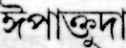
ঈপাক্তুদা
